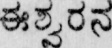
ಈಶ್ವರನ
